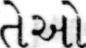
તેઓ
